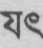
যৎ
